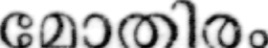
മോതിരം
